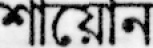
শায়োন
